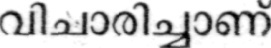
വിചാരിച്ചാണ്
